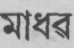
মাধৱ
